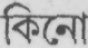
কিনো
